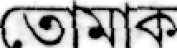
তোমাক
